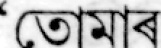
'তোমাৰ
